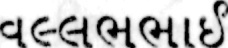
વલ્લભભાઈ
